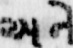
અને
